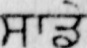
ਸਾਡੇ
